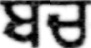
ਬਚ
